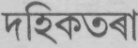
দহিকতৰা
